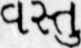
વસ્તુ
